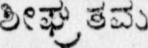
ಶೀಘ್ರತಮ
